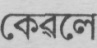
কেৱলে
